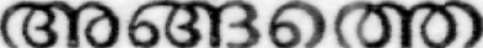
അങ്ങത്തെ
